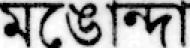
মঙোন্দা
